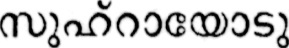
സുഹ്റായോടു
